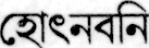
হোৎনবনি
